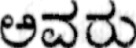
ಅವರು
